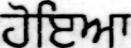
ਹੋਇਆ
